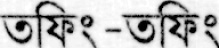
তফিং-তফিং
